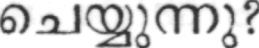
ചെയ്യുന്നു?
